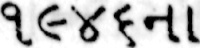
૧૯૪૬ના
